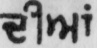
ਦੀਆਂ
